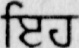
ਇਹ
